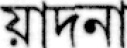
য়াদনা
